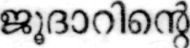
ജൂദാറിന്റെ
